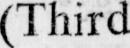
(Third
